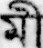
মী
